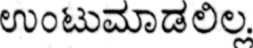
ಉಂಟುಮಾಡಲಿಲ್ಲ.
